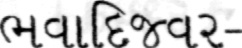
ભવાદિજ્વર-
